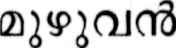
മുഴുവന്‍
